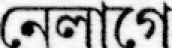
নেলাগে
